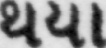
થયા
